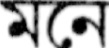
মনে
